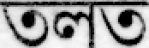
তলত
